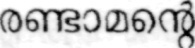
രണ്ടാമന്റെ
